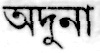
অদুনা
